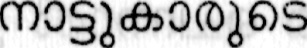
നാട്ടുകാരുടെ
